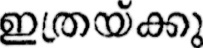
ഇത്രയ്ക്കു
